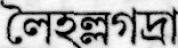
লৈহল্লগদ্রা
